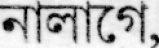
নালাগে,
